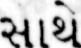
સાથે
